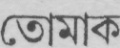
তোমাক
